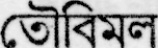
তৌবিমল
